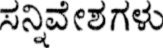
ಸನ್ನಿವೇಶಗಳು
